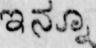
ಇನ್ನೂ
